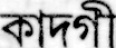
কাদগী
